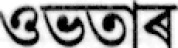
ওভতাৰ
